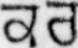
ਕਰ
